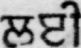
ਲਈ
